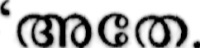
‘അതേ,
